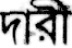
দারী
